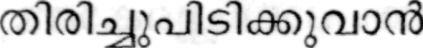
തിരിച്ചുപിടിക്കുവാന്‍
